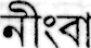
নীংবা
